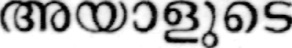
അയാളുടെ
